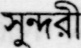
সুন্দরী
